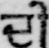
ਦੀ
